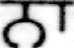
ਨਾ
